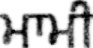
ਮਾਮੀ
